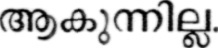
ആകുന്നില്ല.
